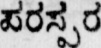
ಪರಸ್ಪರ
